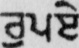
ਰੁਪਏ
